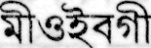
মীওইবগী
